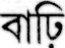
বাঢ়ি
